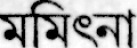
মমিৎনা
